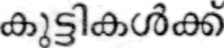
കുട്ടികള്‍ക്ക്
